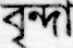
বৃন্দা
